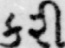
કરી
